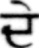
ਦੇ
